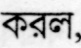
করল,
